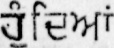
ਹੁੰਦਿਆਂ
